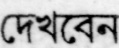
দেখবেন
